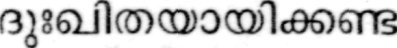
ദുഃഖിതയായിക്കണ്ട
